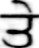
ਤੇ
